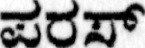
ಪರಸ್
